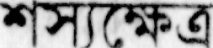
শস্যক্ষেত্র
